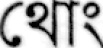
থোং
